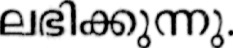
ലഭിക്കുന്നു.
